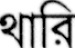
থারি
